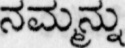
ನಮ್ಮನ್ನು
